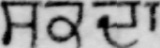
ਸਕਦਾ
